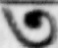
ত
